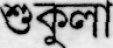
শুকুলা
